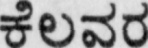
ಕೆಲವರ
